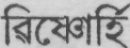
ৱিষ্ণোৰ্হি
